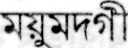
ময়ুমদগী
